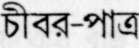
চীবর-পাত্র
